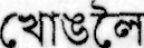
খোঙলৈ
